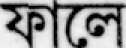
ফালে
